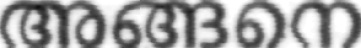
അങ്ങനെ
